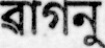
ৱাগনু
